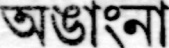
অঙাংনা
